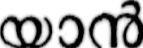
യാന്‍
